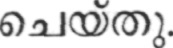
ചെയ്തു.
